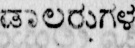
ಡಾಲರುಗಳ
